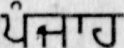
ਪੰਜਾਹ
